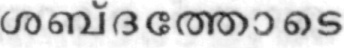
ശബ്ദത്തോടെ
